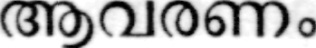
ആവരണം
